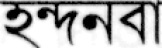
হন্দনবা
